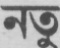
নতু
